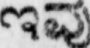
ಇವು
